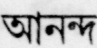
আনন্দ
